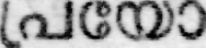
പ്രയോ
